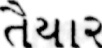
તૈયાર
